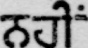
ਨਹੀਂ
